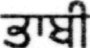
ਭਾਬੀ
